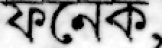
ফনেক,
